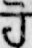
ਹੋ
